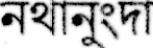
নথানুংদা
